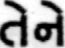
તેને
